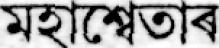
মহাশ্বেতাৰ
